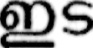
ഇട
